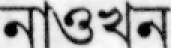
নাওখন
